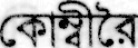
কোম্বীরৈ
